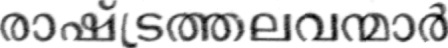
രാഷ്ട്രത്തലവന്മാര്‍
